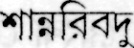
শান্নরিবদু
